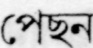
পেছন
